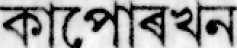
কাপোৰখন
